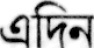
এদিন
